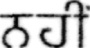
ਨਹੀਂ
